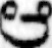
ಆ
